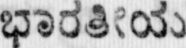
ಭಾರತೀಯ
